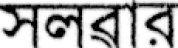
সলৱার
